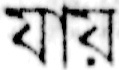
যায়
